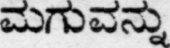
ಮಗುವನ್ನು
